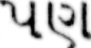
પણ
